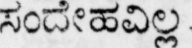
ಸಂದೇಹವಿಲ್ಲ.
